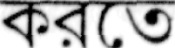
করতে
